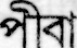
পীবা
